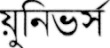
য়ুনিভর্স
